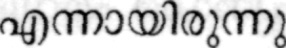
എന്നായിരുന്നു
